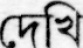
দেখি
